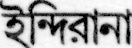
ইন্দিরানা
